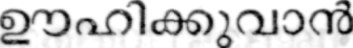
ഊഹിക്കുവാന്‍
